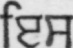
ਇਸ
